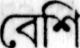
বেশি
